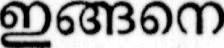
ഇങ്ങനെ
